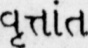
વૃત્તાંત
